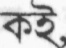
কই,
